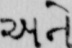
અને
